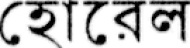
হোরেল
